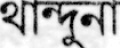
থান্দুনা
